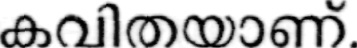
കവിതയാണ്.
